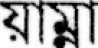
য়াম্না
